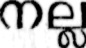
നല്ല
